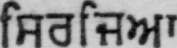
ਸਿਰਜਿਆ
